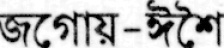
জগোয়-ঈশৈ
